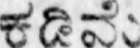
ಕಡಿಮೆ
